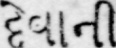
દેવાની
